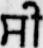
ਸੀ
